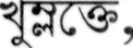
খুম্লক্তে,
